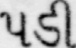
પડી
